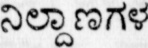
ನಿಲ್ದಾಣಗಳ
